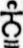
ਨੂੰ
